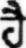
ਹੈ
